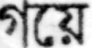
গয়ে
